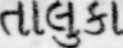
તાલુકા
